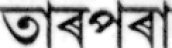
তাৰপৰা
